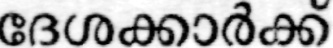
ദേശക്കാര്‍ക്ക്
